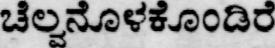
ಚೆಲ್ವನೊಳಕೊಂಡಿರೆ
